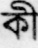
কী
